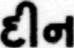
દીન
